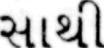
સાથી
